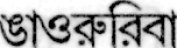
ঙাওরুরিবা
